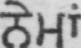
ਨੇਮਾਂ
